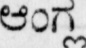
ಆಂಗ್ಲ
